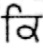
ਕਿ
